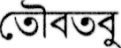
তৌবতবু
